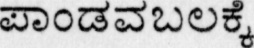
ಪಾಂಡವಬಲಕ್ಕೆ
